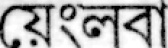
য়েংলবা
